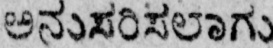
ಅನುಸರಿಸಲಾಗು
